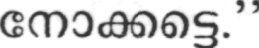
നോക്കട്ടെ."
